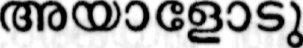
അയാളോടു
